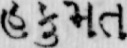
હકુમત
